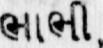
ભાભી,
